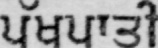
ਪੱਖਪਾਤੀ
